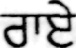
ਰਾਏ
